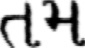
તમ
